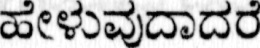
ಹೇಳುವುದಾದರೆ
